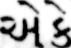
એકે
